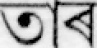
তাৰ
